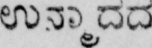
ಉನ್ಮಾದದ
